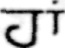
ਹਾਂ
